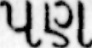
પણ
